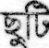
ছুটি
